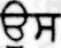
ਉਸ
